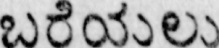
ಬರೆಯಲು
